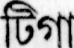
টিগা
